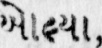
બોલ્યા,
